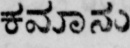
ಕಮಾನು
